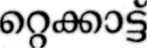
റ്റെക്കാട്ട്
